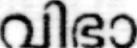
വിഭാ
